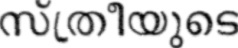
സ്ത്രീയുടെ
